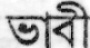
ভাবী
